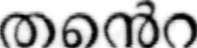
തന്റെ
